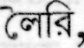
লৈরি,
